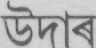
উদাৰ
